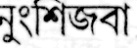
নুংশিজবা
